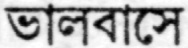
ভালবাসে
